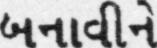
બનાવીને
